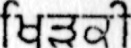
ਖਿੜਕੀ
